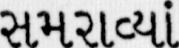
સમરાવ્યાં
